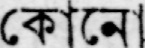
কোনো
